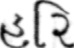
હરિ
